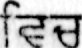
ਵਿਚ
